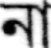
না
